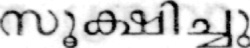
സൂക്ഷിച്ചു
